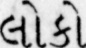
લોકો
